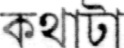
কথাটা
